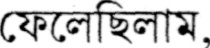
ফেলেছিলাম,
